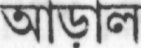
আড়াল
